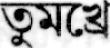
তুমখ্রে
